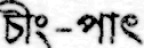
চীং-পাৎ
